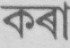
কৰা
